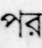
পর
